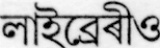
লাইব্রেৰীও
